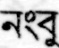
নংবু
